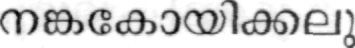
നങ്കകോയിക്കലു
